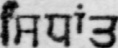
ਸਿਧਾਂਤ
